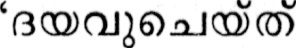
‘ദയവുചെയ്ത്
